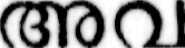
അവ
